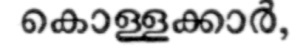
കൊള്ളക്കാര്‍,
